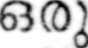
ഒരു
